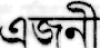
এজনী
